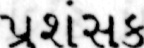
પ્રશંસક
